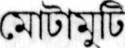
মোটামুটি
